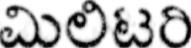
ಮಿಲಿಟರಿ
